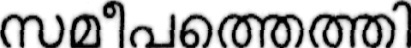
സമീപത്തെത്തി
